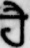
ਹੈ
